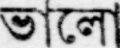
ভালো
